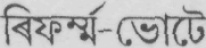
ৰিফৰ্ম্ম-ভোটে
